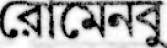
রোমেনবু
